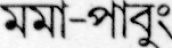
মমা-পাবুং
